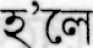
হ'লে
